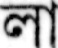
লা
